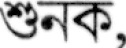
শুনক,
